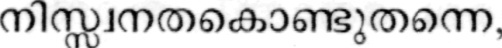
നിസ്സ്വനതകൊണ്ടുതന്നെ,
